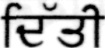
ਦਿੱਤੀ
